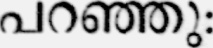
പറഞ്ഞു:
